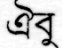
ঐবু
